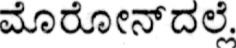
ಮೊರೋನ್ದಲ್ಲೆ.
